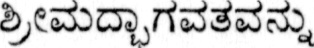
ಶ್ರೀಮದ್ಭಾಗವತವನ್ನು
